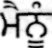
ਮੈਨੂੰ
